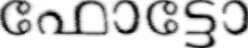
ഫോട്ടോ
